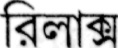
রিলাক্স
